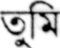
তুমি
